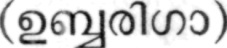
(ഉബ്ബരിഗാ)
